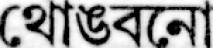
থোঙবনো
